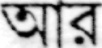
আর
